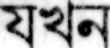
যখন
